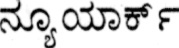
ನ್ಯೂಯಾರ್ಕ್
